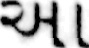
આ
